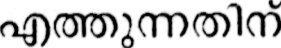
എത്തുന്നതിന്
